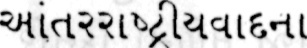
આંતરરાષ્ટ્રીયવાદના
